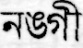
নঙগী
